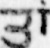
ਤਾਂ
